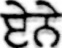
ਏਨੇ
